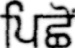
ਪਿਛੋਂ
